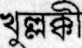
খুল্লক্কী
